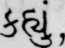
કહ્યું,
